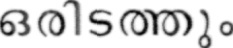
ഒരിടത്തും
